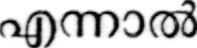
എന്നാല്‍
